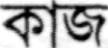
কাজ
